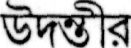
উদন্তীর
